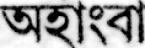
অহাংবা
